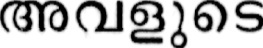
അവളുടെ
